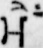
ਮੈਂ
